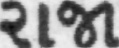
રાજા
